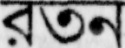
রতন
